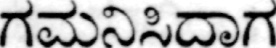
ಗಮನಿಸಿದಾಗ
